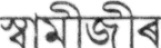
স্বামীজীৰ
